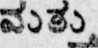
ಮತ್ತು
